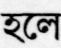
হলে
